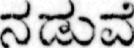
ನಡುವೆ
